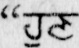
''ਹੁਣ
